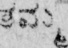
ತಮ್ಮ
